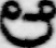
ಆ
